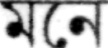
মনে
